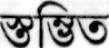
স্তম্ভিত
